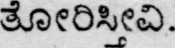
ತೋರಿಸ್ತೀವಿ.
